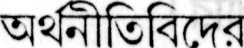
অর্থনীতিবিদের
